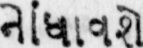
નોંધવશે
